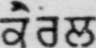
ਕੈਰਲ
